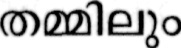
തമ്മിലും
